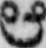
ಆ
